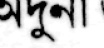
অদুনা
